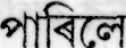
পাৰিলে
